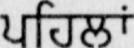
ਪਹਿਲਾਂ
